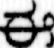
ಈ
